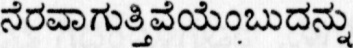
ನೆರವಾಗುತ್ತಿವೆಯೆಂಬುದನ್ನು
